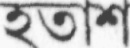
হতাশ
